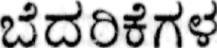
ಬೆದರಿಕೆಗಳ
